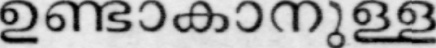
ഉണ്ടാകാനുള്ള
